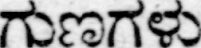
ಗುಣಗಳು
